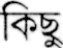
কিছু
